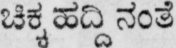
ಚಿಕ್ಕಹದ್ದಿನಂತೆ
